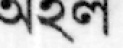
অহল
